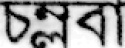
চম্লবা
